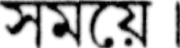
সময়ে।
